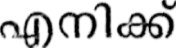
എനിക്ക്
